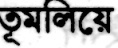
তূমলিয়ে
